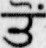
ਤੋਂ
